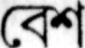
বেশ
